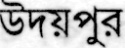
উদয়পুর
